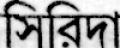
সিরিদা
